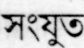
সংযুত
